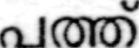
പത്ത്
